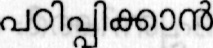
പഠിപ്പിക്കാന്‍
